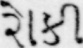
રોકી
